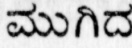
ಮುಗಿದ
